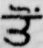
ਤੋਂ
